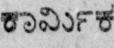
ಕಾರ್ಮಿಕ
